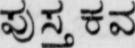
ಪುಸ್ತಕವ
